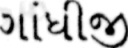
ગાંધીજી
